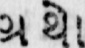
ગ્રંથો
